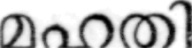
മഹതി
